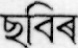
ছবিৰ
